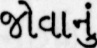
જોવાનું
